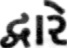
દ્વારે
